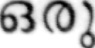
ഒരു
